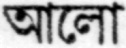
আলো
